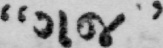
“ગજ”
